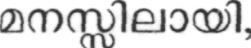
മനസ്സിലായി,
